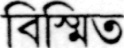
বিস্মিত
